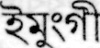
ইমুংগী
